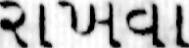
રાખવા
